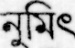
নুমিৎ
